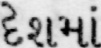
દેશમાં
